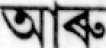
আৰু
